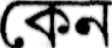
কেন
